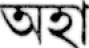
অহা
